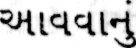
આવવાનું
